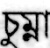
চুম্না
